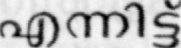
എന്നിട്ട്
